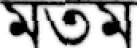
মতম
